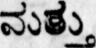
ಮತ್ತು
